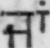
ਜਾਂ
